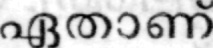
ഏതാണ്
